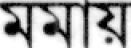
মমায়
